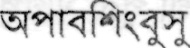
অপাবশিংবুসু
